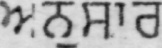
ਅਨੁਸਾਰ
